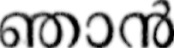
ഞാന്‍
